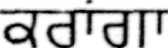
ਕਰਾਂਗਾ
